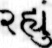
રહ્યું
